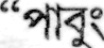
“পাবুং
